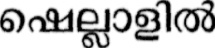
ഷെല്ലാളില്‍
